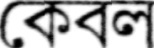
কেবল
